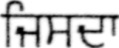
ਜਿਸਦਾ
